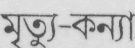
মৃত্যু-কন্যা
